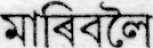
মাৰিবলৈ
